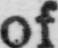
of
